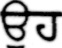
ਉਹ
